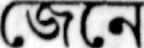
জেনে
